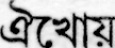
ঐখোয়
